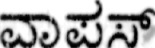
ವಾಪಸ್
